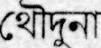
থৌদুনা
